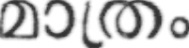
മാത്രം
